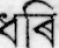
ধৰি
